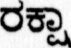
ರಕ್ಷಾ
